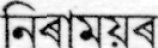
নিৰাময়ৰ
